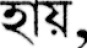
হায়,
